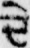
ਦੇ
